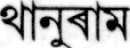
থানুৰাম
